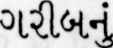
ગરીબનું
